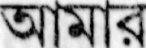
আমার
